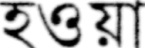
হওয়া
